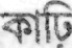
কাঢ়ি
